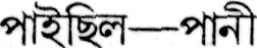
পাইছিল-পানী
